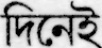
দিনেই
